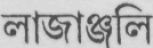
লাজাঞ্জলি
